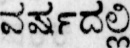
ವರ್ಷದಲ್ಲಿ
